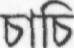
চাচি,
